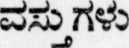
ವಸ್ತುಗಳು
